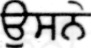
ਉਸਨੇ
